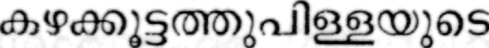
കഴക്കൂട്ടത്തുപിള്ളയുടെ
